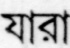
যারা
